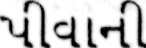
પીવાની
